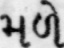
મળે
